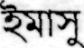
ইমাসু
